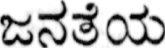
ಜನತೆಯ
